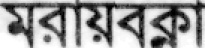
মরায়বক্না
